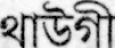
থাউগী
